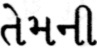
તેમની
